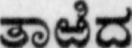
ತಾಱೆದ
